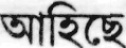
আহিছে
